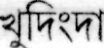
খুদিংদা
